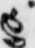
હું
